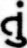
તું
